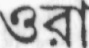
ওরা
